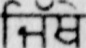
ਜਿੱਥੇ
